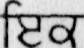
ਇਕ
